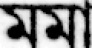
মমা
